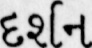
દર્શન
